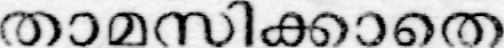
താമസിക്കാതെ
